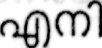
എനി
